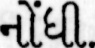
નોંધી.
